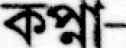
কপ্না-
